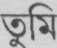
তুমি
